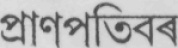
প্ৰাণপতিবৰ
